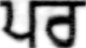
ਪਰ
